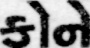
કોને
